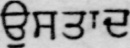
ਉਸਤਾਦ
